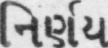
નિર્ણય
